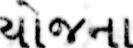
યોજના
